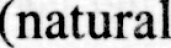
(natural
